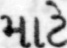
માટે
